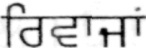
ਰਿਵਾਜਾਂ
